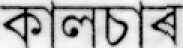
কালচাৰ
